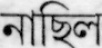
নাছিল
